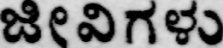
ಜೀವಿಗಳು
